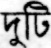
দুটি
